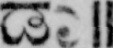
ಡಾ||
